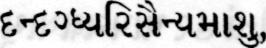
દન્દગ્ધરિસૈન્યમાશુ
